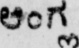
ಅಂಗ್ಲ
